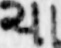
ચા
